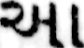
આ
